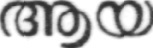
ആയ
